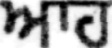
ਆਹ
